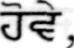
ਹੋਵੇ,
